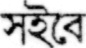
সইবে
